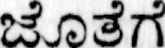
ಜೊತೆಗೆ
